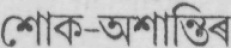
শোক-অশান্তিৰ
